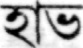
হাভ
